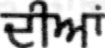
ਦੀਆਂ
